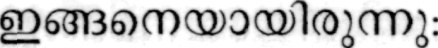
ഇങ്ങനെയായിരുന്നു:
